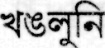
খঙলুনি
